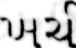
ખર્ચ
